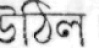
উঠিল
